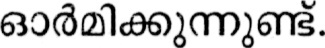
ഓര്‍മിക്കുന്നുണ്ട്.
